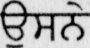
ਉਸਨੇ
